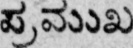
ಪ್ರಮುಖ
